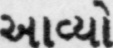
આવ્યો
